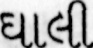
ઘાલી
